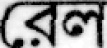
রেল
